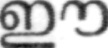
ഈ
